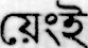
য়েংই
